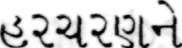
હરચરણને
